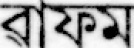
ৱাফম
